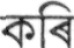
কৰি
